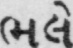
ભલે
